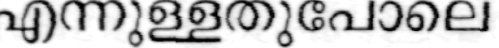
എന്നുള്ളതുപോലെ
